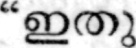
"ഇതു
